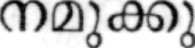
നമുക്കു
